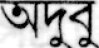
অদুবু
